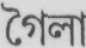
গৈলা
